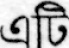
এটি
